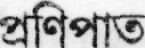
প্রণিপাত
